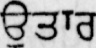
ਉਤਾਰ
